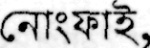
নোংফাই,
